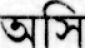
অসি
